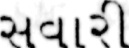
સવારી
